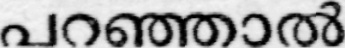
പറഞ്ഞാല്‍
